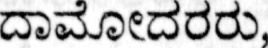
ದಾಮೋದರರು,
